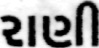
રાણી
